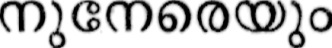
നുനേരെയും
